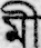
মী
